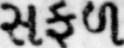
સફળ
